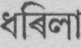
ধৰিলা
